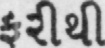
ફરીથી
